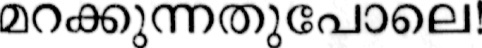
മറക്കുന്നതുപോലെ!
